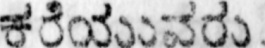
ಕರೆಯುವರು.
